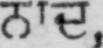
ਨਾਦ,
